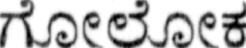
ಗೋಲೋಕ
